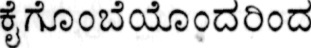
ಕೈಗೊಂಬೆಯೊಂದರಿಂದ
